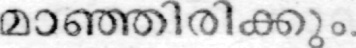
മാഞ്ഞിരിക്കും.
